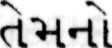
તેમનો
